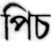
পিচ
